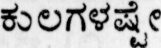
ಕುಲಗಳಷ್ಟೇ
